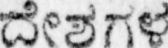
ದೇಶಗಳ
